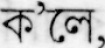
ক'লে,
